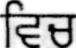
ਵਿਚ
